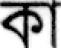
কা
